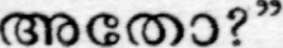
അതോ?''
